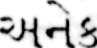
અનેક
